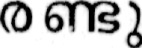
രണ്ടു
